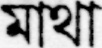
মাথা
